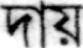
দায়
